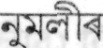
নুমলীৰ
